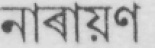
নাৰায়ণ
